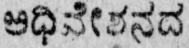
ಅಧಿವೇಶನದ
